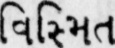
વિસ્મિત
